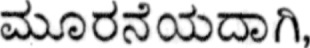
ಮೂರನೆಯದಾಗಿ,
